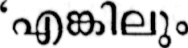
'എങ്കിലും
